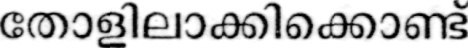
തോളിലാക്കിക്കൊണ്ട്
